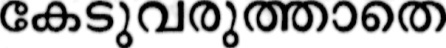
കേടുവരുത്താതെ
